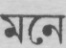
মনে
